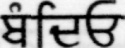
ਬੰਦਿਓ
